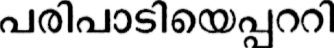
പരിപാടിയെപ്പററി
